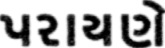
પરાયણે
